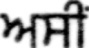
ਅਸੀਂ
